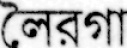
লৈরগা
